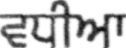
ਵਧੀਆ
